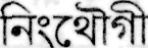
নিংথৌগী
